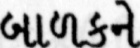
બાળકને
